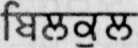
ਬਿਲਕੁਲ
